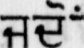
ਜਦੋਂ
